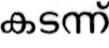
കടന്ന്
